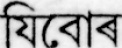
যিবোৰ
